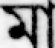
মা
